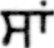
ਸਾਂ
